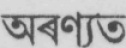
অৰণ্যত
